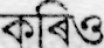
কৰিও
